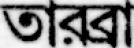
তারব্রা
